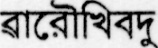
ৱারৌখিবদু
